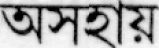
অসহায়
